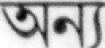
অন্য
